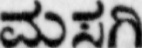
ಮಸಗಿ
